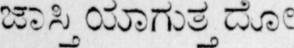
ಜಾಸ್ತಿಯಾಗುತ್ತದೋ
